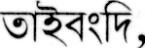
তাইবংদি,
